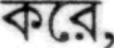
করে,
